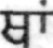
ਥਾਂ
